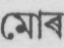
মোৰ
